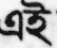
এই
